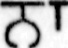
ਨਾ
